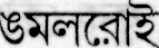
ঙমলরোই
